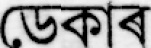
ডেকাৰ
